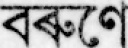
বৰুণে
